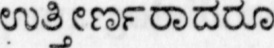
ಉತೀರ್ಣರಾದರೂ
